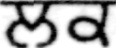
ਲਕ
